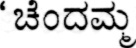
'ಚೆಂದಮ್ಮ
